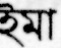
ইমা
